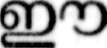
ഈ
